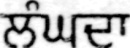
ਲੰਘਦਾ
